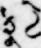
ફુટે
